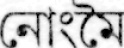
নোংমৈ
